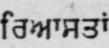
ਰਿਆਸਤਾਂ
